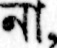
না,
